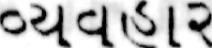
વ્યવહાર
